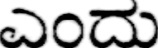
ಎಂದು
